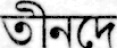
তীনদে
